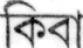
কিবা
